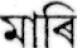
মাৰি
